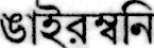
ঙাইরম্বনি
